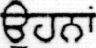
ਉਹਨਾਂ
